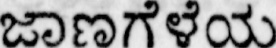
ಜಾಣಗೆಳೆಯ
